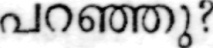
പറഞ്ഞു?
